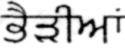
ਭੈੜੀਆਂ
